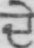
ਦੇ
